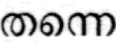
തന്നെ
